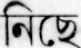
নিছে
